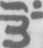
ਤੋਂ
